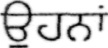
ਉਹਨਾਂ
